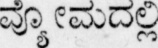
ವ್ಯೋಮದಲ್ಲಿ
